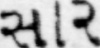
સાર
